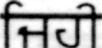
ਜਿਹੀ
